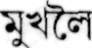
মুখলৈ
